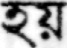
হয়
